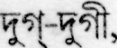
দুগ্-দুগী,
